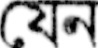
যেন
